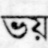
ভয়
